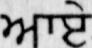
ਆਏ
